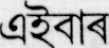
এইবাৰ
